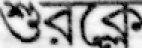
শুরক্লে
